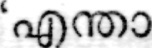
‘എന്താ
